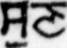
ਸੁਣ
